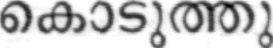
കൊടുത്തു
